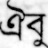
ঐবু
